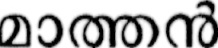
മാത്തന്‍
